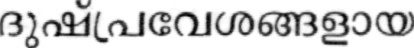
ദുഷ്പ്രവേശങ്ങളായ
